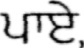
ਪਾਏ,
